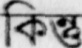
কিন্তু
